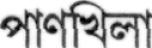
পাণখিলা
